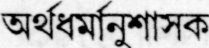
অর্থধর্মানুশাসক
